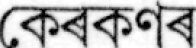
কেৰকণৰ
